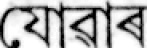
যোৱাৰ
